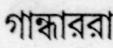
গান্ধাররা
